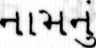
નામનું
